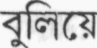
বুলিয়ে
